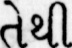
તેથી
